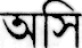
অসি
